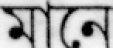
মানে
